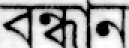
বন্ধান
